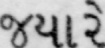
જ્યારે
